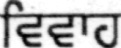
ਵਿਵਾਹ
